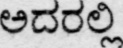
ಅದರಲ್ಲಿ
